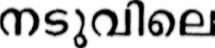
നടുവിലെ
